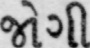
જોગી
